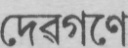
দেৱগণে
